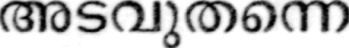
അടവുതന്നെ
